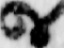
જ
